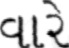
વારે
